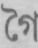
গৈ
